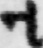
ન
